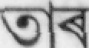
তাৰ
